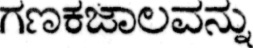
ಗಣಕಜಾಲವನ್ನು
